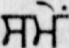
ਸਮੇਂ
